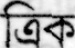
ত্রিক
